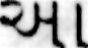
આ
